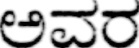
ಅವರ
